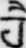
ਹੈ
